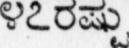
೪೭ರಷ್ಟು
